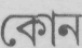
কোন
